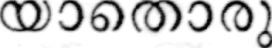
യാതൊരു
